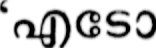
‘എടോ
